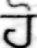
ਹੋ
